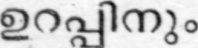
ഉറപ്പിനും
